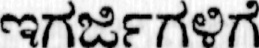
ಇಗರ್ಜಿಗಳಿಗೆ
